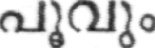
പൂവും
